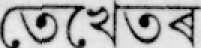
তেখেতৰ
